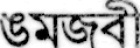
ঙমজবী
